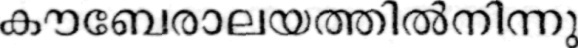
കൌബേരാലയത്തില്‍നിന്നു
